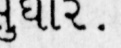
સુધાર.
